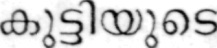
കുട്ടിയുടെ
